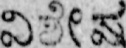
ವಿಶೇಷ
